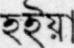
হইয়া
